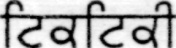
ਟਿਕਟਿਕੀ
